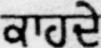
ਕਾਹਦੇ
